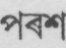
পৰশ
